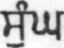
ਸੁੰਘ
